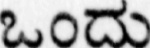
ಒಂದು
